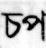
চপ
